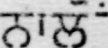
ਨਾਲੋਂ
